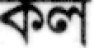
কল
